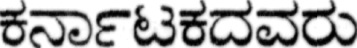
ಕರ್ನಾಟಕದವರು
